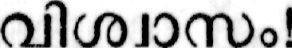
വിശ്വാസം!
